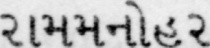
રામમનોહર
